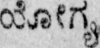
ಯೋಗ್ಯ
